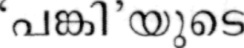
‘പങ്കി’യുടെ
